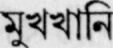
মুখখানি
